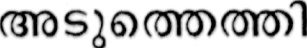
അടുത്തെത്തി
